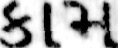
કામ
